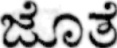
ಜೊತೆ
